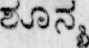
ಶೂನ್ಯ
